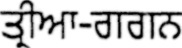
ਤ੍ਰੀਆ-ਗਗਨ
